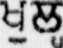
ਖੁਲ੍ਹ
